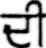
ਦੀ
